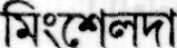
মিংশেলদা
